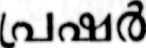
പ്രഷര്‍
